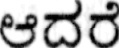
ಆದರೆ
